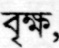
বৃক্ষ,
